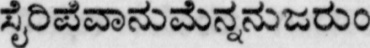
ಸೈರಿಪೆವಾನುಮೆನ್ನನುಜರುಂ
